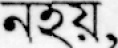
নহয়,
